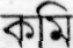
কমি
